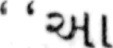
"આ
